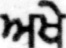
ਅਖੇ
